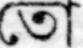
তো
